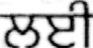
ਲਈ
